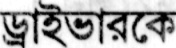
ড্রাইভারকে
